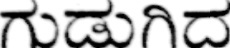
ಗುಡುಗಿದ
